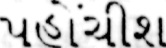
પહોંચીશ
